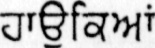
ਹਾਉਕਿਆਂ
